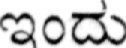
ಇಂದು
